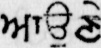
ਆਉਣੇ
